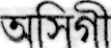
অসিগী
